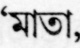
‘মাতা,
